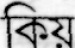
কিয়
